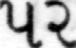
પર
